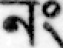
নং
